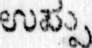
ಉಪ್ಪು
